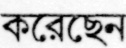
করেছেন
